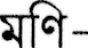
মণি-
